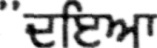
''ਦਇਆ
